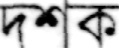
দশক
